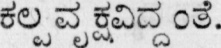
ಕಲ್ಪವೃಕ್ಷವಿದ್ದಂತೆ.
